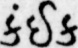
કંઈક
